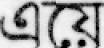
এয়ে
